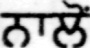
ਨਾਲੋਂ
